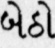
બેઠો
